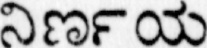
ನಿರ್ಣಯ
